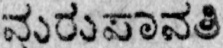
ಮರುಪಾವತಿ
